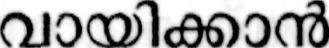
വായിക്കാന്‍
